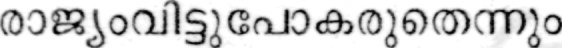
രാജ്യംവിട്ടുപോകരുതെന്നും
